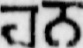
ਹਨ
